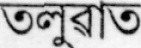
তলুৱাত
